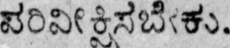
ಪರಿವೀಕ್ಷಿಸಬೇಕು.
